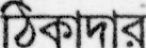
ঠিকাদার
